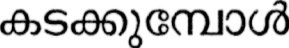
കടക്കുമ്പോള്‍
